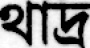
থাদ্র
